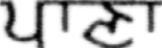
ਪਾਣਾ
